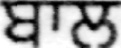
ਬਾਲ
